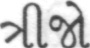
ત્રીજો
